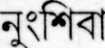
নুংশিবা
